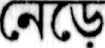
নেড়ে
